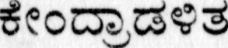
ಕೇಂದ್ರಾಡಳಿತ
